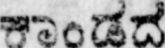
ಕಾಂಡದ
